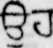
ਉਹ
